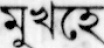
মুখহে
